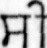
ਸੀ
